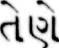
તેણે
